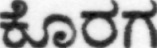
ಕೊರಗ
